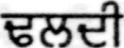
ਢਲਦੀ
